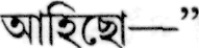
আহিছো-"
